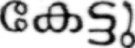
കേട്ടു
